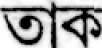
তাক
